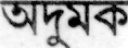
অদুমক
